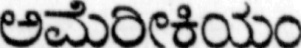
ಅಮೆರೀಕಿಯಂ
